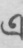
এ
